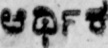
ಆರ್ಥಿಕ
